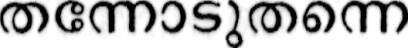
തന്നോടുതന്നെ
